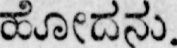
ಹೋದನು.
